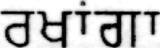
ਰਖਾਂਗਾ
